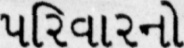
પરિવારનો
